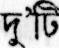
দু’টি
